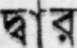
দ্বার
